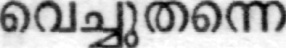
വെച്ചുതന്നെ
